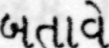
બતાવે
